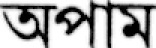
অপাম
